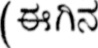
(ಈಗಿನ
